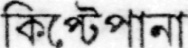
কিপ্টেপানা
